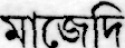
মাজেদি
